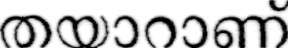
തയാറാണ്
